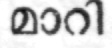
മാറി
